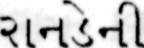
રાનડેની
